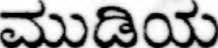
ಮುಡಿಯ
